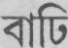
বাঢ়ি
